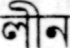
লীন
